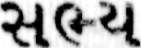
સભ્ય
